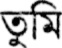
তুমি
